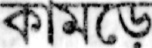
কামড়ে
